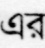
এর
